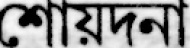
শোয়দনা
